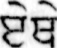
ਏਥੇ
